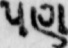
પણ
